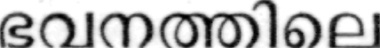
ഭവനത്തിലെ
